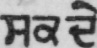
ਸਕਦੇ
